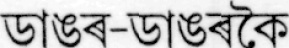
ডাঙৰ-ডাঙৰকৈ
